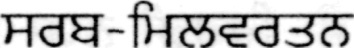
ਸਰਬ-ਮਿਲਵਰਤਨ
